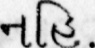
નહિ.
